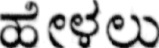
ಹೇಳಲು
